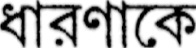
ধারণাকে
